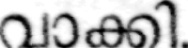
വാക്കി.
